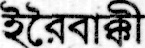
ইরৈবাক্কী
